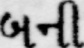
બની
